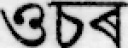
ওচৰ
